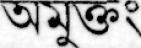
অমুক্তং
